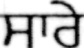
ਸਾਰੇ
